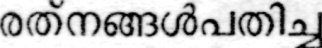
രത്നങ്ങള്‍പതിച്ച
